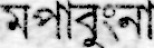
মপাবুংনা
